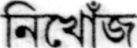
নিখোঁজ
